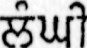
ਲੰਘੀ
